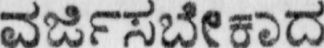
ವರ್ಜಿಸಬೇಕಾದ
